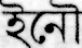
ইনৌ
